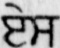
ਏਸ
